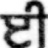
ਈ
